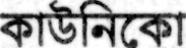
কাউনিকো
